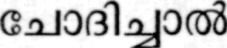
ചോദിച്ചാല്‍
